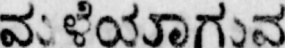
ಮಳೆಯಾಗುವ
